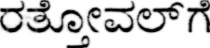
ರತ್ತೋವಲ್ಗೆ
